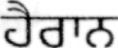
ਹੈਰਾਨ
